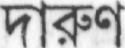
দারুণ
